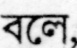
বলে,
